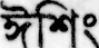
ঈশিং
